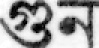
গুন
